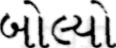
બોલ્યો
